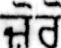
ਜ਼ੋਰੋ
